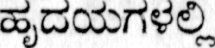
ಹೃದಯಗಳಲ್ಲಿ
